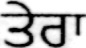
ਤੇਰਾ
